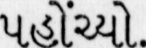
પહોંચ્યો.
